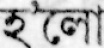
হ'লো
